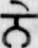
ਨੇ
